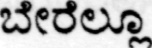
ಬೇರೆಲ್ಲೂ
